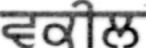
ਵਕੀਲ
